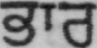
ਭਾਰ
